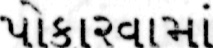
પોકારવામાં
